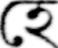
হে
